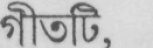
গীতটি,
